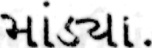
માંડ્યા.
